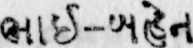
ભાઈ-બહેન
